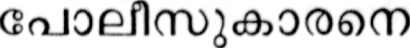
പോലീസുകാരനെ
